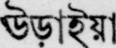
উড়াইয়া
